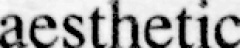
aesthetic
